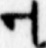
ન
